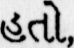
હતો,
